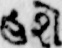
હશે
